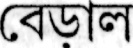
বেড়াল
